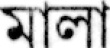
মালা
